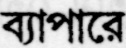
ব্যাপারে
